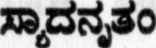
ಸ್ಯಾದನೃತ೦
